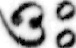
ওঃ
